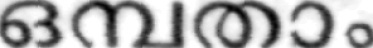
ഒമ്പതാം
